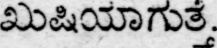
ಖುಷಿಯಾಗುತ್ತೆ.
